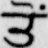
ਤੋਂ
